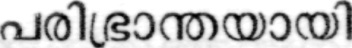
പരിഭ്രാന്തയായി
